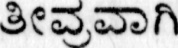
ತೀವ್ರವಾಗಿ
